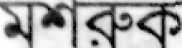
মশরুক
